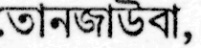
তোনজাউবা,
